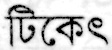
টিকেৎ
